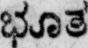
ಭೂತ
